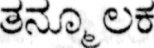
ತನ್ಮೂಲಕ
